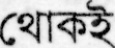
থোকই
